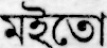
মইতো
